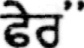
ਫੇਰ''
